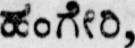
ಹಂಗೇರಿ,
